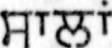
ਸਾਲਾਂ
